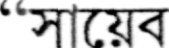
“সায়েব
